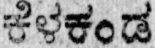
ಕೆಳಕಂಡ
